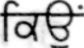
ਕਿਉਂ
